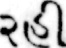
રહી
